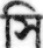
সি
